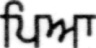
ਪਿਆ
